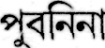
পুবনিনা
